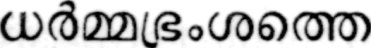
ധര്‍മ്മഭ്രംശത്തെ
